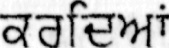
ਕਰਦਿਆਂ
